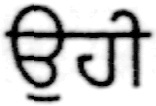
ਉਹੀ
